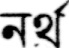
নর্থ
